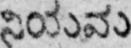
ನಿಯಮ
